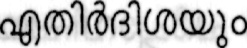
എതിര്‍ദിശയും
